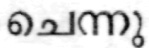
ചെന്നു
